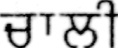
ਚਾਲੀ
